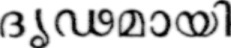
ദൃഢമായി
